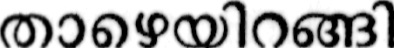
താഴെയിറങ്ങി
